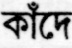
কাঁদে
